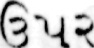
ઉપર
